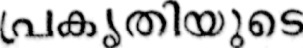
പ്രകൃതിയുടെ
